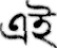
এই
